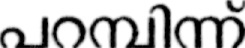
പറമ്പിന്ന്
